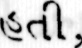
હતી,
